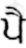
ਪੈ
